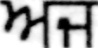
ਅਜ
